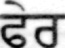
ਫੇਰ
